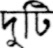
দুটি
